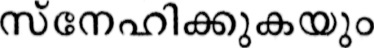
സ്നേഹിക്കുകയും
